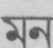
মন
